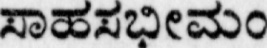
ಸಾಹಸಭೀಮಂ
